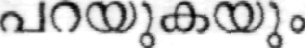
പറയുകയും
